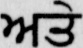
ਅਤੇ
